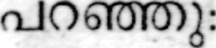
പറഞ്ഞു:
